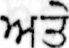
ਅਤੇ
